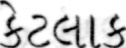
કેટલાક
